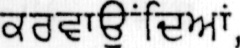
ਕਰਵਾਉਂਦਿਆਂ,
